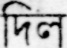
দিল
